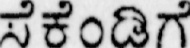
ಸೆಕೆಂಡಿಗೆ
